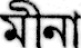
মীনা
